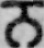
ਨ
